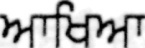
ਆਖਿਆ
